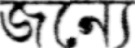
জন্যে
